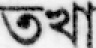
তখা
